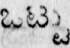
ಒಟ್ಟು
